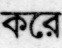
করে
